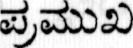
ಪ್ರಮುಖ
